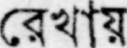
রেখায়
